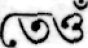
তেওঁ
